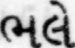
ભલે
